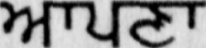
ਆਪਣਾ
